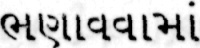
ભણાવવામાં
